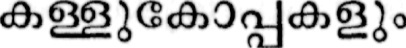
കള്ളുകോപ്പകളും
